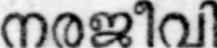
നരജീവി
